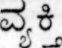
ವ್ಯಕ್ತಿ
